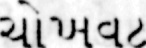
ચોખવટ
